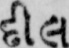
દીલ
